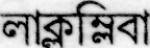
লাক্লম্লিবা
